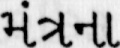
મંત્રના
